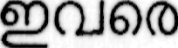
ഇവരെ
